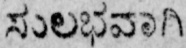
ಸುಲಭವಾಗಿ
